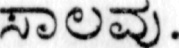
ಸಾಲವು.
